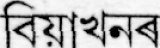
বিয়াখনৰ
